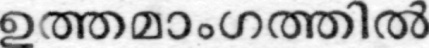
ഉത്തമാംഗത്തില്‍
